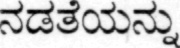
ನಡತೆಯನ್ನು
